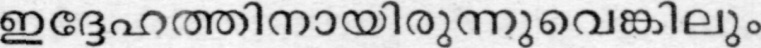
ഇദ്ദേഹത്തിനായിരുന്നുവെങ്കിലും
